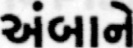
અંબાને
